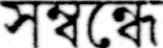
সম্বন্ধে
